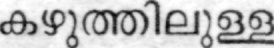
കഴുത്തിലുള്ള
